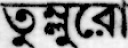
তুম্লুরো
